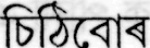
চিঠিবোৰ
